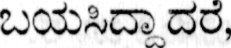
ಬಯಸಿದ್ದಾದರೆ,
